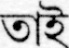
তাই
